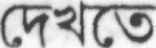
দেখতে
